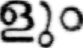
ളും
